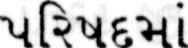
પરિષદમાં
